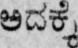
ಅದಕ್ಕೆ
